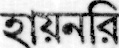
হায়নরি,
